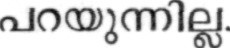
പറയുന്നില്ല.
